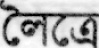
লৈত্রে
